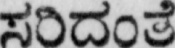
ಸರಿದಂತೆ
